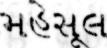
મહેસૂલ
